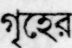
গৃহের
